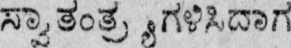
ಸ್ವಾತಂತ್ರ್ಯಗಳಿಸಿದಾಗ
